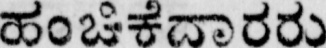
ಹಂಚಿಕೆದಾರರು
